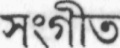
সংগীত
